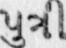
પુત્રી
